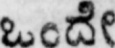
ಒಂದೇ
